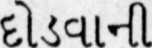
દોડવાની
